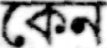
কেন
